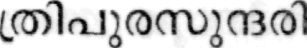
ത്രിപുരസുന്ദരി
